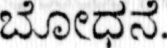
ಬೋಧನೆ.
